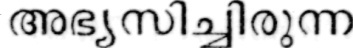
അഭ്യസിച്ചിരുന്ന
